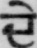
ਦੇ
